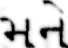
મને
